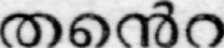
തന്റെ
